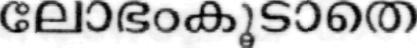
ലോഭംകൂടാതെ
